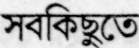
সবকিছুতে
